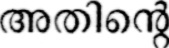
അതിന്റെ
